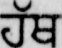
ਹੱਥ
